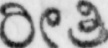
ರೀತಿ
